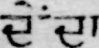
ਦੇਂਦਾ
